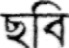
ছবি
